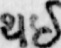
થઈ
